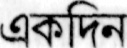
একদিন
